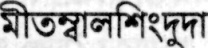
মীতম্বালশিংদুদা
